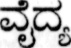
ವೈದ್ಯ
